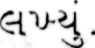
લખ્યું.
